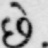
છે.
